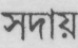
সদায়
